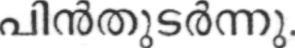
പിന്‍തുടര്‍ന്നു.
